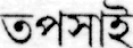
তপসাই
